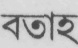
বতাহ
